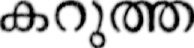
കറുത്ത
